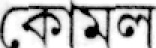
কোমল
